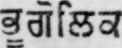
ਭੂਗੋਲਿਕ
